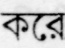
করে
